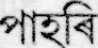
পাহৰি
